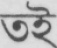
তই
